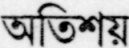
অতিশয়
